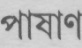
পাষাণ
